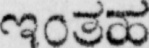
ಇಂತಹ
